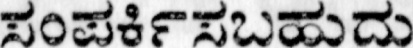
ಸಂಪರ್ಕಿಸಬಹುದು
